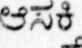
ಆಸಕ್ತಿ
